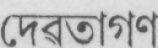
দেৱতাগণ
